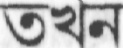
তখন
